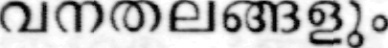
വനതലങ്ങളും
